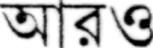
আরও
